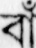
বাঁ
